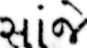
સાંજે
